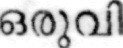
ഒരുവി
